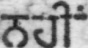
ਨਹੀਂ
